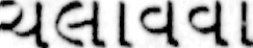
ચલાવવા
